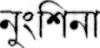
নুংশিনা
